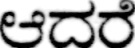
ಆದರೆ
